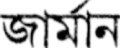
জার্মান
